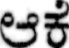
ಆಕೆ
